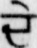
ਦੇ
